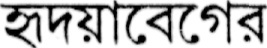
হৃদয়াবেগের
